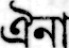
ঐনা
